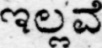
ಇಲ್ಲವೆ
